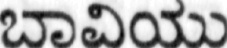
ಬಾವಿಯು
